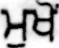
ਮੁਖੋਂ
